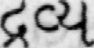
દ્રવ્ય
